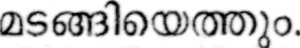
മടങ്ങിയെത്തും.
